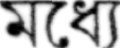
মধ্যে
